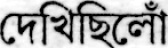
দেখিছিলোঁ
